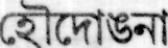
হৌদোঙনা
